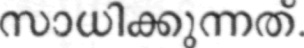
സാധിക്കുന്നത്.
